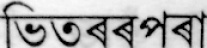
ভিতৰৰপৰা
